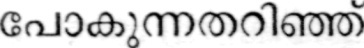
പോകുന്നതറിഞ്ഞ്
